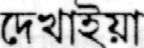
দেখাইয়া
